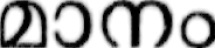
മാനം
